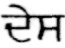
ਦੇਸ
